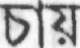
চায়
